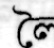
লৈ
